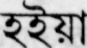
হইয়া
